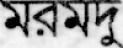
মরমদু
